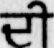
ਦੀ
